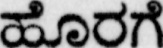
ಹೊರಗೆ
